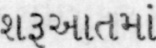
શરૂઆતમાં
